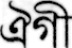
ঐগী
